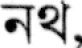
নথ,
